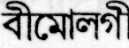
বীমোলগী
